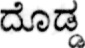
ದೊಡ್ಡ
